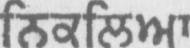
ਨਿਕਲਿਆ
